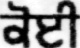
ਕੋਈ
